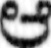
ಆ
